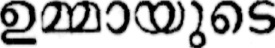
ഉമ്മായുടെ
